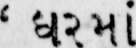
'ઘરમાં
